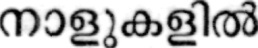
നാളുകളില്‍
